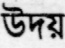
উদয়
